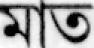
মাত
